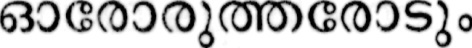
ഓരോരുത്തരോടും
